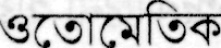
ওতোমেতিক
